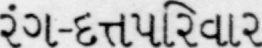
રંગ-દત્તપરિવાર
